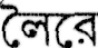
লৈরে
